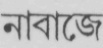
নাবাজে
